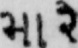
મારે
